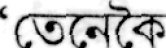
'তেনেকৈ
